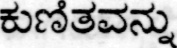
ಕುಣಿತವನ್ನು
